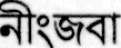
নীংজবা
